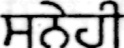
ਸਨੇਹੀ
